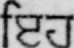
ਇਹ
